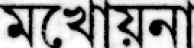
মখোয়না
